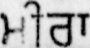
ਮੀਰਾ
